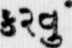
કરવું
